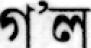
গ'ল
